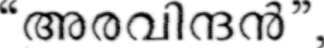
"അരവിന്ദന്‍",
